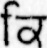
ਕਿ
